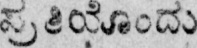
ಪ್ರತಿಯೊಂದು
